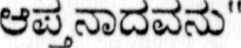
ಆಪ್ತನಾದವನು”
